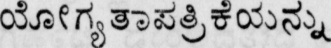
ಯೋಗ್ಯತಾಪತ್ರಿಕೆಯನ್ನು
